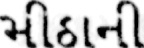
મીઠાની
